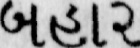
બહાર
